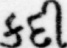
કદી
